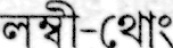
লম্বী-থোং
